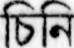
চিনি
